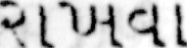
રાખવા
